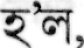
হ'ল,
